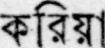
করিয়া
